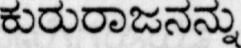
ಕುರುರಾಜನನ್ನು
